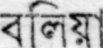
বলিয়া
